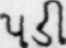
પડી
